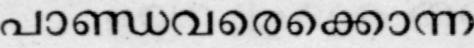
പാണ്ഡവരെക്കൊന്ന
